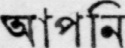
আপনি
